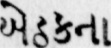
બેઠકના
